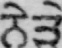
ਨੇੜੇ
